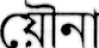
য়ৌনা
